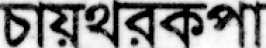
চায়থরকপা
